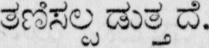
ತಣಿಸಲ್ಪಡುತ್ತದೆ.
